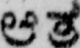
ಆತ
